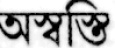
অস্বস্তি
